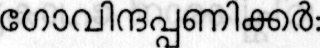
ഗോവിന്ദപ്പണിക്കര്‍:
